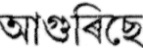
আগুৰিছে
